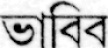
ভাবিব
